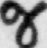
જ
